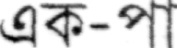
এক-পা
